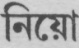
নিয়ো
